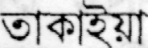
তাকাইয়া
